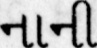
નાની
